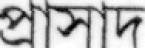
প্ৰাসাদ
